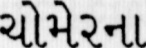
ચોમેરના
